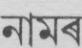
নামৰ
